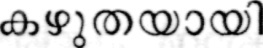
കഴുതയായി
